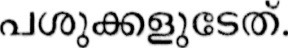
പശുക്കളുടേത്.
